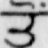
ਤੋਂ
